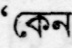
‘কেন
